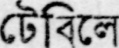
টেবিলে
